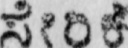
ಸೇರಿಕೆ
